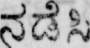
ನಡೆಸಿ
